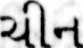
ચીન
